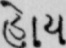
હોય
